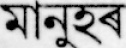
মানুহৰ
